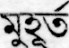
মুহূর্ত
